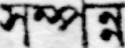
সম্পন্ন
